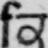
ਕਿ
